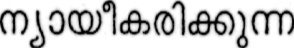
ന്യായീകരിക്കുന്ന
